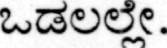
ಒಡಲಲ್ಲೇ.
